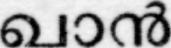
ഖാന്‍
